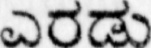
ಎರಡು
